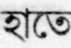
হাতে
